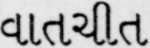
વાતચીત
